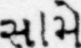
સામે
